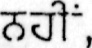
ਨਹੀਂ,
